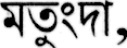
মতুংদা,
